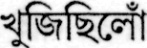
খুজিছিলোঁ
